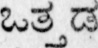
ಒತ್ತಡ
